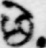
છે.
